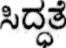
ಸಿದ್ಧತೆ
